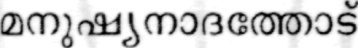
മനുഷ്യനാദത്തോട്
